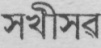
সখীসৱ
